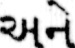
અને
